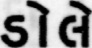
ડોલે
